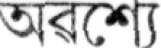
অৱশ্যে
